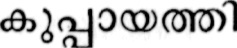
കുപ്പായത്തി
